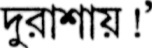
দুরাশায়!’
